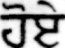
ਹੋਏ
